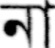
না
